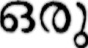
ഒരു
